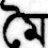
মৈ
